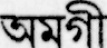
অমগী
